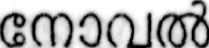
നോവല്‍
